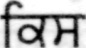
ਕਿਸ
